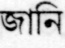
জানি
